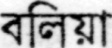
বলিয়া
